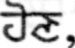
ਹੋਣ,
